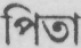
পিতা
